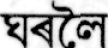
ঘৰলৈ
